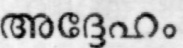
അദ്ദേഹം
